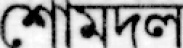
শোমদল
